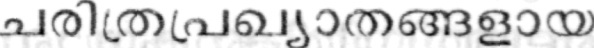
ചരിത്രപ്രഖ്യാതങ്ങളായ
